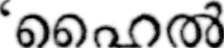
"ഹൈല്‍
